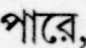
পারে,
